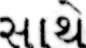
સાથે
